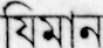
যিমান
